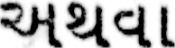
અથવા
